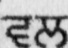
ਵਲ
